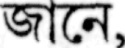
জানে,
